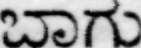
ಬಾಗು
